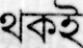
থকই
